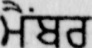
ਮੈਂਬਰ
